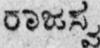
ರಾಜಸ್ವ
